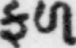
ફળ
